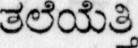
ತಲೆಯೆತ್ತಿ
